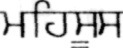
ਮਹਿਸੂਸ
